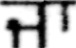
ਜਾ
